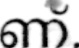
ണ്.
